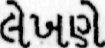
લેખણે
